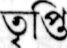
তৃপ্তি
